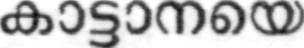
കാട്ടാനയെ
